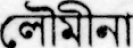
লৌমীনা
